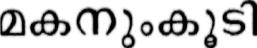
മകനുംകൂടി
